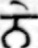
ਨੇ
